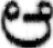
ಆ
